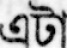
এটা
